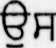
ਉਸ
